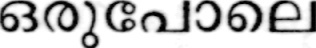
ഒരുപോലെ
